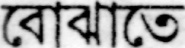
বোঝাতে
